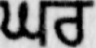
ਘਰ
